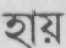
হায়
